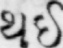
થઈ
